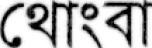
থোংবা
